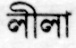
লীলা
